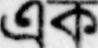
এক
